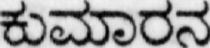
ಕುಮಾರನ
